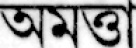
অমত্তা
